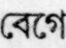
বেগে
